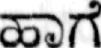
ಹಾಗೆ
